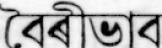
বৈৰীভাব
